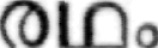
രഥം
